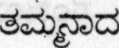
ತಮ್ಮನಾದ
